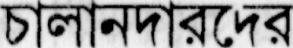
চালানদারদের
